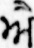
ਐ
